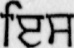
ਇਸ
